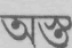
অস্ত
